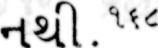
નથી.૧૬૮
